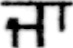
ਜਾ
